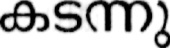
കടന്നു
